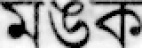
মঙক
